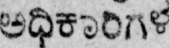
ಅಧಿಕಾರಿಗಳ
